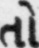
તો
